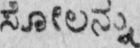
ಸೋಲನ್ನು
